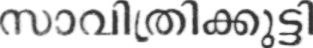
സാവിത്രിക്കുട്ടി
